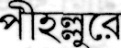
পীহল্লুরে
